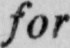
for
